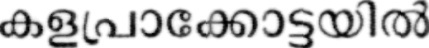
കളപ്രാക്കോട്ടയില്‍
